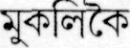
মুকলিকৈ
